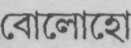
বোলোহো
